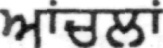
ਆਂਚਲਾਂ
